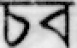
চব
